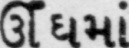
ઊંઘમાં
